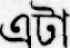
এটা
